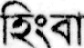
হিংবা
